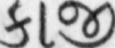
કાજી
